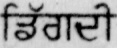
ਡਿੱਗਦੀ
